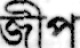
জীপা
